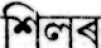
শিলৰ
